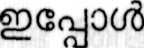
ഇപ്പോള്‍
